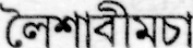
লৈশাবীমচা
